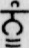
ਨੂੰ
